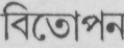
বিতোপন
